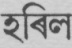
হৰিল
